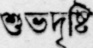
শুভদৃষ্টি
